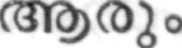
ആരും
